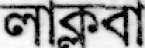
লাক্লবা
